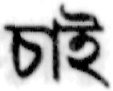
চাই
